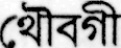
থৌবগী
